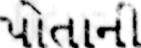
પોતાની
